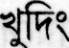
খুদিং
